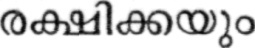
രക്ഷിക്കയും
